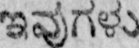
ಇವುಗಳು
